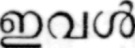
ഇവള്‍
